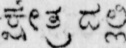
ಕ್ಷೇತ್ರದಲ್ಲಿ
